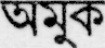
অমুক
